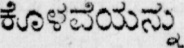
ಕೊಳವೆಯನ್ನು
